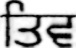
ਤਿਵ
